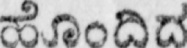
ಹೊಂದಿದ
